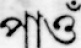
পাওঁ
